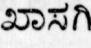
ಖಾಸಗಿ
